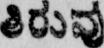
ತಿರುವು
